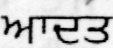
ਆਦਤ
